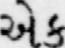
એક
